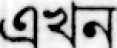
এখন
